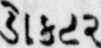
ડોક્ટર
